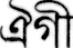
ঐগী
